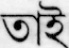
তাই
